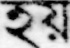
হয়
